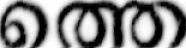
ത്തെ
